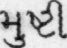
મુષ્ટી
